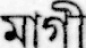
মাগী
